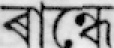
ৰান্ধে
